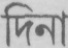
দিনা
